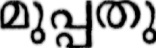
മുപ്പതു
